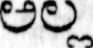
ಅಲ್ಲ
